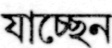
যাচ্ছেন
